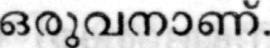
ഒരുവനാണ്.
